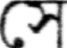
সে
